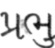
પ્રભુ
